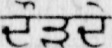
ਦੌੜਦੇ
